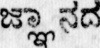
ಜ್ಞಾನದ
